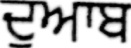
ਦੁਆਬ
